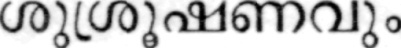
ശുശ്രൂഷണവും
